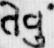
તેવું
